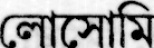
লোসোমি
